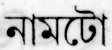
নামটো
